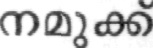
നമുക്ക്
